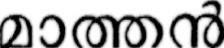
മാത്തന്‍
